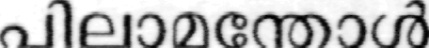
പിലാമന്തോള്‍
